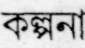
কল্পনা
